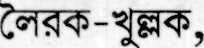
লৈরক-খুল্লক,
